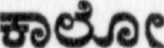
ಕಾಲೋ
